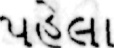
પહેલા
